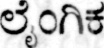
ಲೈಂಗಿಕ
